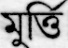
মুর্ত্তি
